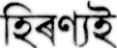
হিৰণ্যই
